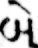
બે
